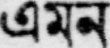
এমন
